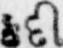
કદી
